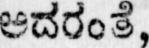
ಅದರಂತೆ,
